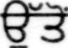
ਉੱਤੋਂ
